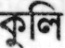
কুলি
